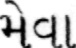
મેવા
